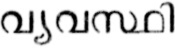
വ്യവസ്ഥി
